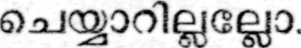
ചെയ്യാറില്ലല്ലോ.
